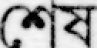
শেষ
